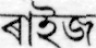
ৰাইজ
